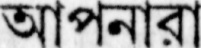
আপনারা
